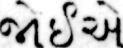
જોઇએ
